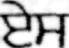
ਏਸ
